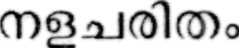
നളചരിതം
